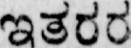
ಇತರರ
